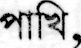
পাখি,
